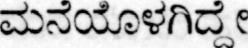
ಮನೆಯೊಳಗಿದ್ದೇ
